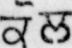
ਕੋਲ
